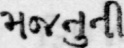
મજનુની
